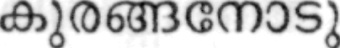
കുരങ്ങനോടു
